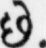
છે.
